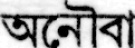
অনৌবা
